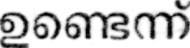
ഉണ്ടെന്ന്
